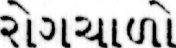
રોગચાળો
